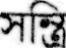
সন্ত্রি
